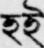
হই
